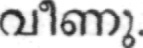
വീണു.
